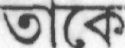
তাকে
